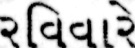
રવિવારે
